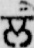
ਲੈ
